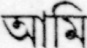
আমি
